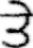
ਤੇ
